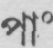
পা
